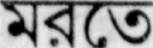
মরতে
